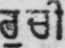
ਰੁਚੀ
